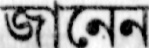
জানেন
